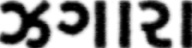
ઝગારા
